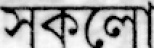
সকলো
